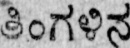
ತಿಂಗಳಿನ
